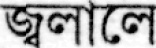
জ্বলালে
